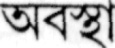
অবস্থা
